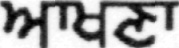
ਆਖਣਾ
